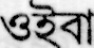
ওইবা
